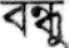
বন্ধু
